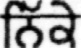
ਨਿੱਕੇ
